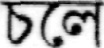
চলে
